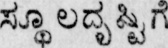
ಸ್ಥೂಲದೃಷ್ಟಿಗೆ
